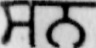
ਸਨ
